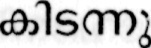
കിടന്നു
